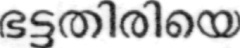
ഭട്ടതിരിയെ
